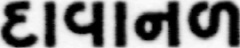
દાવાનળ
